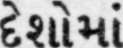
દેશોમાં
